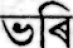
ভৰি
